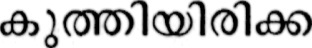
കുത്തിയിരിക്ക
